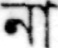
না
